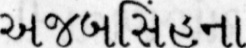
અજબસિંહના
